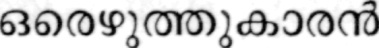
ഒരെഴുത്തുകാരന്‍
